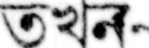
তখন
